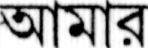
আমার
